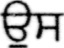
ਉਸ
